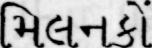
મિલનકોં
